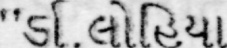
"ર્ડા.લોહિયા
